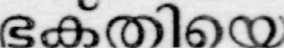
ഭക്തിയെ
